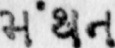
મંથન
